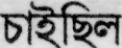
চাইছিল
